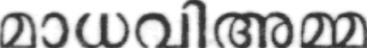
മാധവിഅമ്മ
